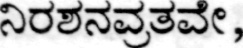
ನಿರಶನವ್ರತವೇ,
